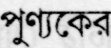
পুণ্যকের
